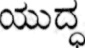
ಯುದ್ಧ
